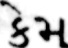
કેમ
